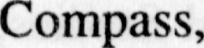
Compass,
